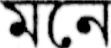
মনে
